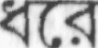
ধরে
